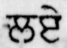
ਲਏ
